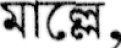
মাল্লে,
